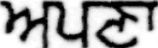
ਅਪਣਾ
